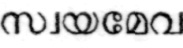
സ്വയമേവ
